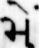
મેં
